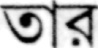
তার
